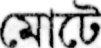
মোটে
